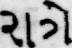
રાત્રે
